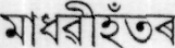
মাধৱীহঁতৰ
